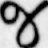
જ
